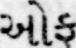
ઓફ
